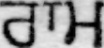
ਰਾਮ
